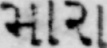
મારા
